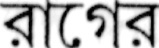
রাগের
